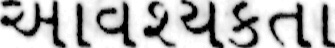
આવશ્યકતા
